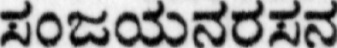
ಸಂಜಯನರಸನ
